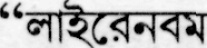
“লাইরেনবম
